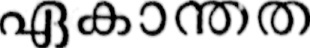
ഏകാന്തത
